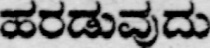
ಹರಡುವುದು
